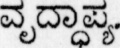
ವೃದ್ಧಾಪ್ಯ.
